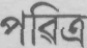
পৱিত্র
